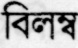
বিলম্ব
